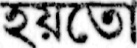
হয়তো
